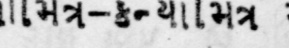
સ્ત્રીમિત્ર-કન્યામિત્ર
